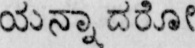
ಯನ್ನಾದರೋ
